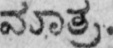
ಮಾತ್ರ.
